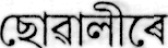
ছোৱালীৰে
